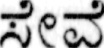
ಸೇವೆ
